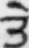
ਤੇ
